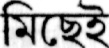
মিছেই
